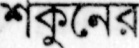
শকুনের
